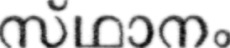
സ്ഥാനം
